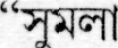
"সুমলা
